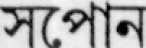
সপোন
